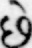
છે
